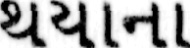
થયાના
